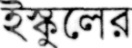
ইস্কুলের
